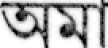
অমা
